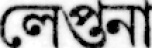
লেপ্তনা
